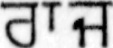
ਰਾਜ
